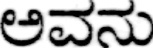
ಅವನು
